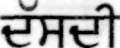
ਦੱਸਦੀ
